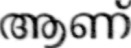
ആണ്
